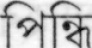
পিন্ধি
